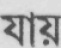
যায়
